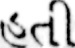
હતી
